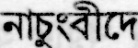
নাচুংবীদে
